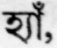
হ্যাঁ,
